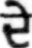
ਦੇ
